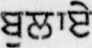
ਬੁਲਾਏ
